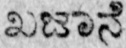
ಖಜಾನೆ
